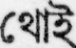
থোই
